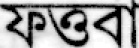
ফত্তবা
